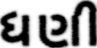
ધણી
